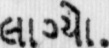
લાગ્યો.
